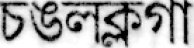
চঙলক্লগা
